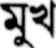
মুখ
